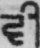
ਵੀ
